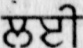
ਲਈ
